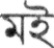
মই
